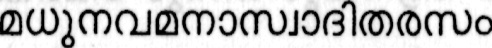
മധുനവമനാസ്വാദിതരസം
